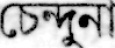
চেন্দুনা
